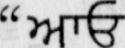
''ਆਓ
